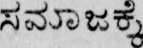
ಸಮಾಜಕ್ಕೆ
